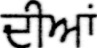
ਦੀਆਂ
